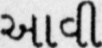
આવી
